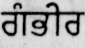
ਗੰਭੀਰ
